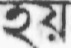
হয়
